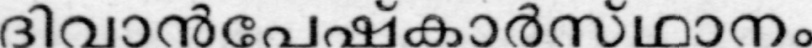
ദിവാന്‍പേഷ്കാര്‍സ്ഥാനം
